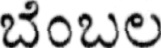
ಬೆಂಬಲ
